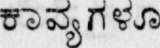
ಕಾವ್ಯಗಳೂ
